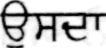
ਉਸਦਾ
